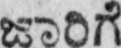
ಜಾರಿಗೆ
